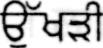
ਉੱਖੜੀ
